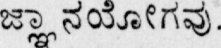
ಜ್ಞಾನಯೋಗವು.
